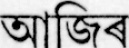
আজিৰ
